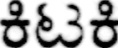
ಕಿಟಕಿ
